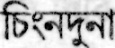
চিংনদুনা
